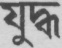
যুদ্ধ
